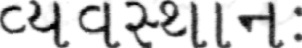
વ્યવસ્થાનઃ
